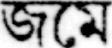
জমে
